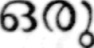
ഒരു
